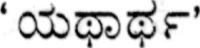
'ಯಥಾರ್ಥ'
